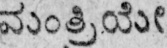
ಮಂತ್ರಿಯೇ
